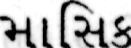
માસિક
